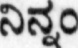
ನಿನ್ನಂ
